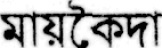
মায়কৈদা
